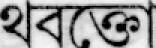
থবক্তো
